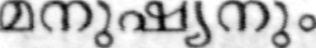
മനുഷ്യനും
